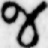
જ
